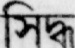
সিদ্ধ
